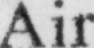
Air
